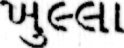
ખુલ્લા
